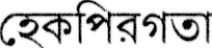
হেকপিরগতা
